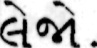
લેજો.
